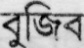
বুজিব
